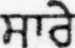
ਸਾਰੇ
